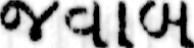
જવાબ
